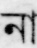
না
